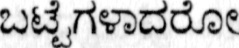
ಬಟ್ಟೆಗಳಾದರೋ
